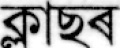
ক্লাছৰ
